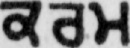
ਕਰਮ
